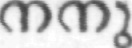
നനു
